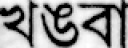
খঙবা
